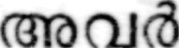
അവര്‍
